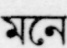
মনে
